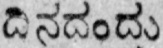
ದಿನದಂದು
